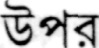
উপর
